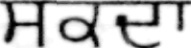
ਸਕਦਾ
